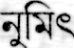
নুমিৎ
